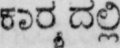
ಕಾರ್ಯದಲ್ಲಿ
